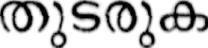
തുടരുക
